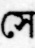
সে
